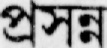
প্রসন্ন
